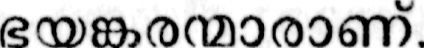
ഭയങ്കരന്മാരാണ്.
